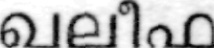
ഖലീഫ
